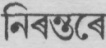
নিৰন্তৰে
